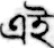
এই
